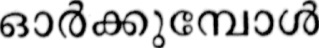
ഓര്‍ക്കുമ്പോള്‍
